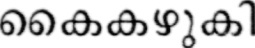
കൈകഴുകി
